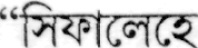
"সিফালেহে
